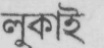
লুকাই
